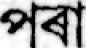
পৰা
